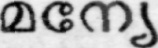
മന്യേ
